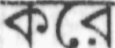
করে
